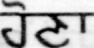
ਹੋਣਾ
